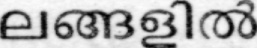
ലങ്ങളില്‍
